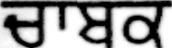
ਚਾਬਕ
